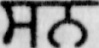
ਸਨ
